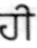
ਹੀ
